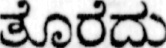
ತೊರೆದು
